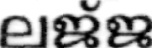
ലജ്ജ
